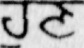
ਹੁਣ
